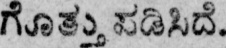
ಗೊತ್ತುಪಡಿಸಿದೆ.
